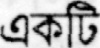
একটি
